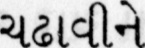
ચઢાવીને
